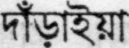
দাঁড়াইয়া
